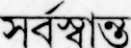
সর্বস্বান্ত
